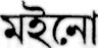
মইনো
